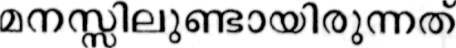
മനസ്സിലുണ്ടായിരുന്നത്
